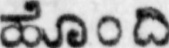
ಹೊಂದಿ
